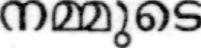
നമ്മുടെ
